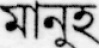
মানুহ
